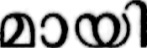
മായി
